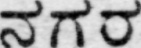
ನಗರ
